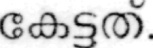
കേട്ടത്.
